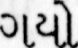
ગયો
